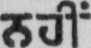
ਨਹੀਂ
